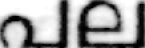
പല
